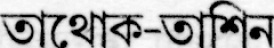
তাথোক-তাশিন
